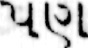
પણ
